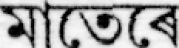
মাতেৰে
